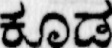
ಕೂಡ
